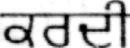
ਕਰਦੀ
